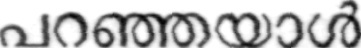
പറഞ്ഞയാള്‍
